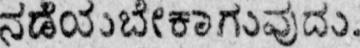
ನಡೆಯಬೇಕಾಗುವುದು.
